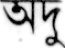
অদু
